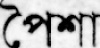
পৈশা
